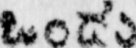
ಒಂದು
